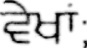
ਵੇਖਾਂ;
